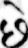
છે
